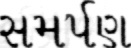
સમર્પણ
